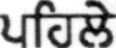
ਪਹਿਲੇ
